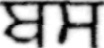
ਬਸ
